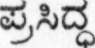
ಪ್ರಸಿದ್ಧ
